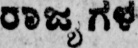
ರಾಜ್ಯಗಳ
